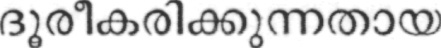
ദൂരീകരിക്കുന്നതായ
